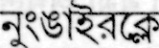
নুংঙাইরক্লে
